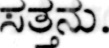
ಸತ್ತನು.
